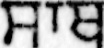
ਸਾਥ
